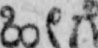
ಹೀಗೆ
